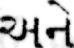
અને
